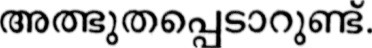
അത്ഭുതപ്പെടാറുണ്ട്.
